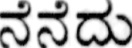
ನೆನೆದು
